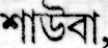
শাউবা,
